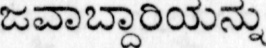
ಜವಾಬ್ದಾರಿಯನ್ನು
